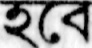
হবে
